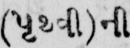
(પૃથ્વી)ની
